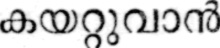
കയറ്റുവാന്‍
